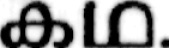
കഥ.
